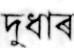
দুধাৰ
